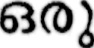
ഒരു
